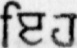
ਇਹ
